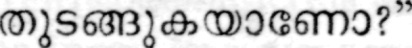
തുടങ്ങുകയാണോ?”
